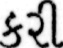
કરી
